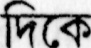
দিকে
